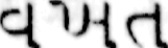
વખત
